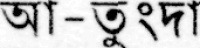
আ-তুংদা
